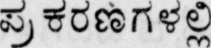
ಪ್ರಕರಣಗಳಲ್ಲಿ
